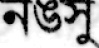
নঙসু
